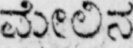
ಮೇಲಿನ
